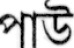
পাউ
